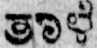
ತಾಳೆ
